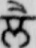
ਲੈ
